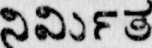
ನಿರ್ಮಿತ
